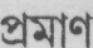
প্ৰমাণ
